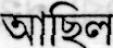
আছিল
